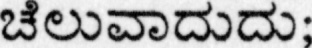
ಚೆಲುವಾದುದು;
